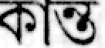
কান্ত
